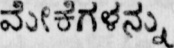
ಮೇಕೆಗಳನ್ನು
